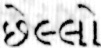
છેલ્લો
